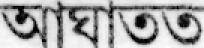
আঘাতত
